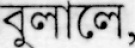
বুলালে,
